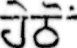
ਹੇਠੋਂ
